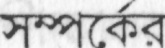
সম্পর্কের
